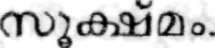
സൂക്ഷ്മം.
